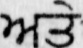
ਅਤੇ
